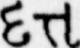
દત્ત
